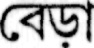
বেড়া
